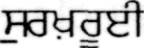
ਸੁਰਖ਼ਰੂਈ
